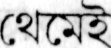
থেমেই
